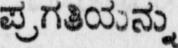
ಪ್ರಗತಿಯನ್ನು
